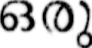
ഒരു
